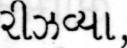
રીઝવ્યા,
